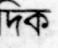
দিক
